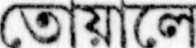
তোয়ালে
